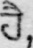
ਹੈ,
